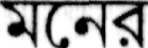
মনের
